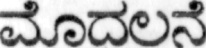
ಮೊದಲನೆ
